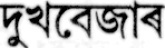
দুখবেজাৰ
